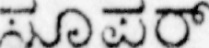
ಸೂಪರ್
